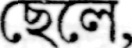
ছেলে,
